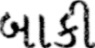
બાકી
